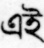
এই
